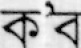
ক'ব
